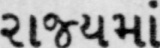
રાજ્યમાં
